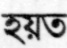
হয়ত
